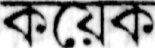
কয়েক
